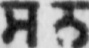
ਸਨ
